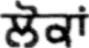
ਲੋਕਾਂ
